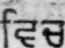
ਵਿਚ
